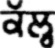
ਕੱਲ੍ਹ
